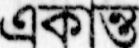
একান্ত
